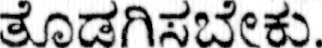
ತೊಡಗಿಸಬೇಕು.
